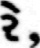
રે,
